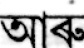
আৰু
